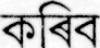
কৰিব
